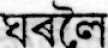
ঘৰলৈ
